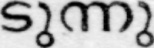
ടുന്നു
